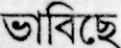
ভাবিছে
